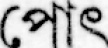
পোৎ
